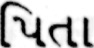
પિતા
